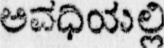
ಅವಧಿಯಲ್ಲಿ
